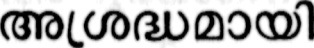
അശ്രദ്ധമായി
